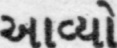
આવ્યો
